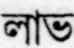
লাভ
